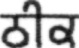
ਠੀਕ
